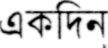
একদিন
